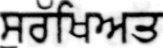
ਸੁਰੱਖਿਅਤ
